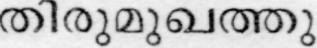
തിരുമുഖത്തു
